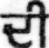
ਦੀ
